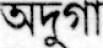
অদুগা
